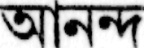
আনন্দ
